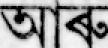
আৰু
